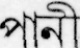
পানী
